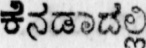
ಕೆನಡಾದಲ್ಲಿ
